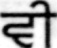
ਵੀ
